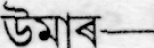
উমাৰ-
